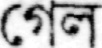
গেল
